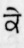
ਕੇ
